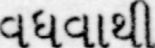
વધવાથી
